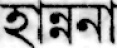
হান্ননা
